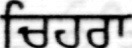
ਚਿਹਰਾ
